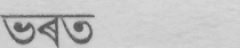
ভৰত
